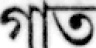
গাত
